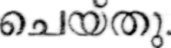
ചെയ്തു.
